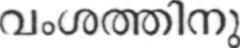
വംശത്തിനു
